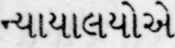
ન્યાયાલયોએ
